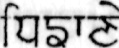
ਧਿਙਾਣੇ
